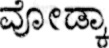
ವೋಡ್ಕಾ
